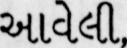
આવેલી,
